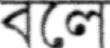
বলে
